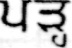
ਪੜ੍ਹ
